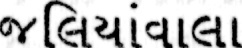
જલિયાંવાલા
